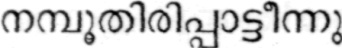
നമ്പൂതിരിപ്പാട്ടീന്നു
